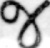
જ
